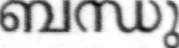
ബന്ധു
